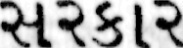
સરકાર
